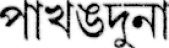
পাখঙদুনা
